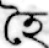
হৈ
